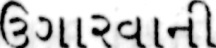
ઉગારવાની
